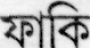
ফাকি
